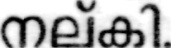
നല്കി.
